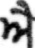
ਐ
